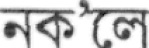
নক'লে
